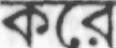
করে
